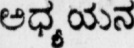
ಅಧ್ಯಯನ
